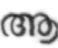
ആ
